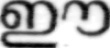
ഈ
